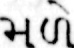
મળે
